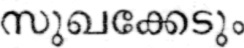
സുഖക്കേടും
